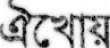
ঐখোয়
